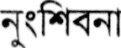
নুংশিবনা
